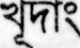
খূদাং
